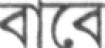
বাবে
